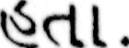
હતા.
